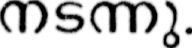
നടന്നു.
